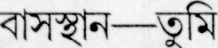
বাসস্থান-তুমি
